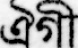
ঐগী
